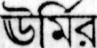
ঊর্মির
